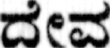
ದೇವ
